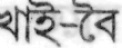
খাই-বৈ
